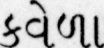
કવેળા
